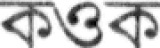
কওক
